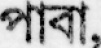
পাবা,
